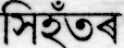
সিহঁতৰ
